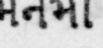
મનમાં
